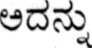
ಅದನ್ನು
